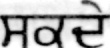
ਸਕਦੇ
